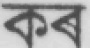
কৰ
